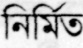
নির্মিত
